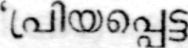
‘പ്രിയപ്പെട്ട
